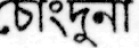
চোংদুনা
